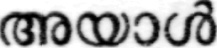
അയാള്‍
